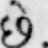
છે.
